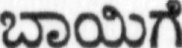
ಬಾಯಿಗೆ
